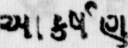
આકર્ષણ
